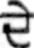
ਦੇ
